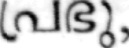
പ്രഭു,
